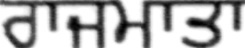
ਰਾਜਮਾਤਾ
